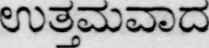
ಉತ್ತಮವಾದ
